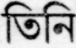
তিনি
